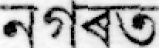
নগৰত
